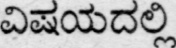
ವಿಷಯದಲ್ಲಿ
